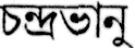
চন্দ্রভানু
